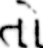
તો
